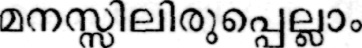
മനസ്സിലിരുപ്പെല്ലാം
